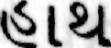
હાથ
